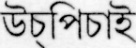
উচ্‌পিচাই
